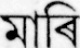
মাৰি
